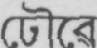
ঢৌৱে
